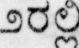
೨ರಲ್ಲಿ
